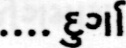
............દુર્ગા
